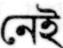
নেই
